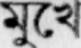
মুখে
